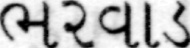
ભરવાડ
